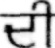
ਦੀ
